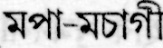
মপা-মচাগী
